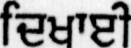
ਦਿਖਾਈ
